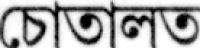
চোতালত
